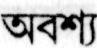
অবশ্য
